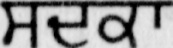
ਸਦਕਾ
